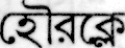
হৌরক্লে
